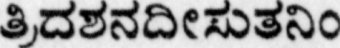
ತ್ರಿದಶನದೀಸುತನಿಂ
